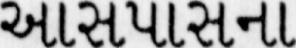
આસપાસના
